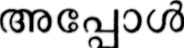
അപ്പോള്‍
